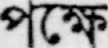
পক্ষে
